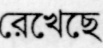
রেখেছে
